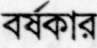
বর্ষকার
